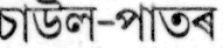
চাউল-পাতৰ
